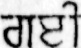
ਗਈ
